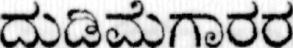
ದುಡಿಮೆಗಾರರ
